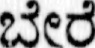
ಬೇರೆ
